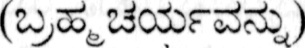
(ಬ್ರಹ್ಮಚರ್ಯವನ್ನು)
